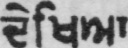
ਦੇਖਿਆ
